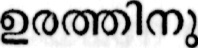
ഉരത്തിനു
